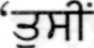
'ਤੁਸੀਂ
